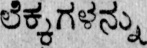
ಲೆಕ್ಕಗಳನ್ನು
